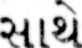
સાથે
